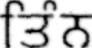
ਤਿੰਨ
